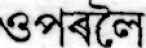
ওপৰলৈ
